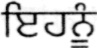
ਇਹਨੂੰ
